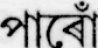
পাৰোঁ
